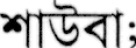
শাউবা;
